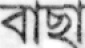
বাছা
